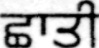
ਛਾਤੀ
